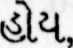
હોય,
